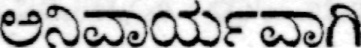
ಅನಿವಾರ್ಯವಾಗಿ
